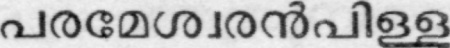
പരമേശ്വരന്‍പിള്ള
